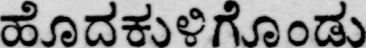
ಹೊದಕುಳಿಗೊಂಡು
